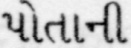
પોતાની
